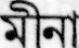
মীনা
